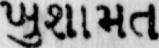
ખુશામત
